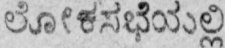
ಲೋಕಸಭೆಯಲ್ಲಿ
